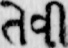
તેવી
